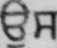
ਉਸ
